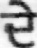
ਦੇ
